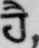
ਹੈ,
